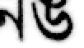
নঙ
